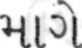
માગે
